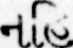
નહિ
